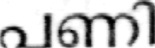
പണി
